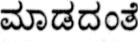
ಮಾಡದಂತೆ
